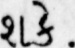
શકે.
